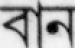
বান
